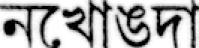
নখোঙদা
